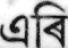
এৰি
